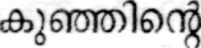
കുഞ്ഞിന്റെ
